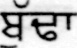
ਬੁੱਢਾ
